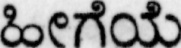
ಹೀಗೆಯೆ
